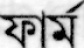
ফার্ম
